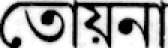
তোয়না
